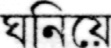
ঘনিয়ে
